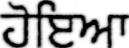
ਹੋਇਆ
